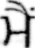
ਮੈਂ
